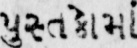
પુસ્તકોમાં
